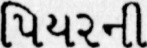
પિયરની
